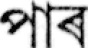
পাৰ
